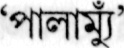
‘পালাম্যুঁ’
